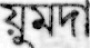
য়ুমদা
